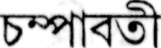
চম্পাবতী
